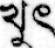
খুৎ
